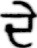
ਦੇ
